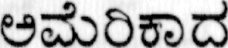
ಅಮೆರಿಕಾದ
